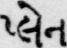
પ્લેન
